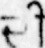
ਦੀ
